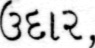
ઉદાર,
